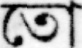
তো
